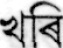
খৰি
